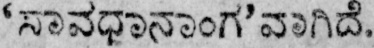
‘ಸಾವಧಾನಾಂಗ’ವಾಗಿದೆ.
